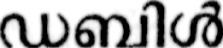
ഡബിള്‍
